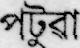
পটুৱা
